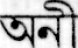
অনী
